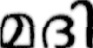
മദി
